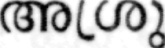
അശ്രു
